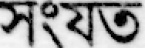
সংযত
